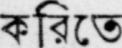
করিতে
